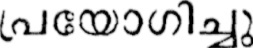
പ്രയോഗിച്ചു
